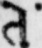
તેં
